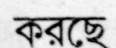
করছে
